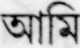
আমি
